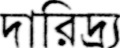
দারিদ্র্য
